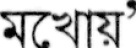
মখোয়’
